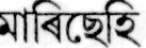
মাৰিছেহি
